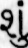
શું
